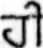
ਹੀ
